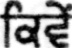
ਕਿਵੇਂ
